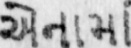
એનામાં
